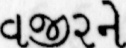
વજીરને
